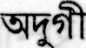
অদুগী
